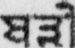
ਬੜੀ
